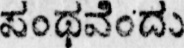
ಪಂಥವೆಂದು
